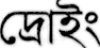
দ্রোইং
